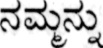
ನಮ್ಮನ್ನು
